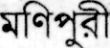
মণিপুরী
